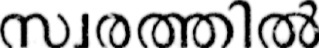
സ്വരത്തില്‍
